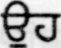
ਉਹ
